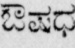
ಔಷಧ
